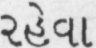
રહેવા
